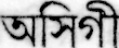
অসিগী
